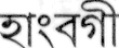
হাংবগী
